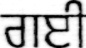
ਗਈ
